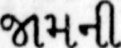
જામની
